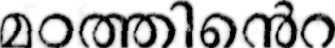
മഠത്തിന്റെ
